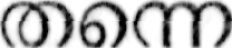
തന്നെ
